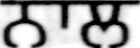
ਨਾਲ
